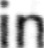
in
